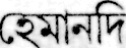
হেমানদি
